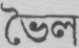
ভৈল
